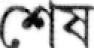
শেষ
